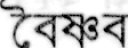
বেষ্ণব
